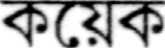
কয়েক
